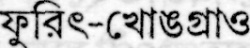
ফুরিৎ-খোঙগ্রাও
